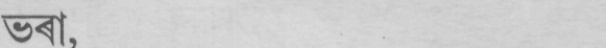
ভৰা,
